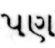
પણ
